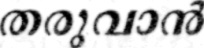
തരുവാന്‍
